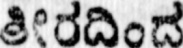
ತೀರದಿಂದ
